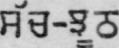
ਸੱਚ-ਝੂਠ
